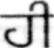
ਹੀ
